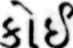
કોઈ
